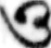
ও
